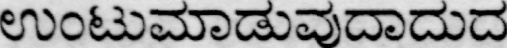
ಉಂಟುಮಾಡುವುದಾದುದ
